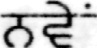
ਨਵੇਂ
